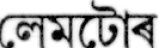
লেমটোৰ
